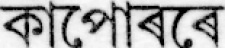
কাপোৰৰে
